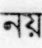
নয়
